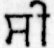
ਸੀ
